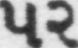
પર
